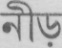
নীড়
